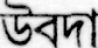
উবদা
